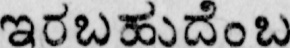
ಇರಬಹುದೆಂಬ
